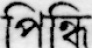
পিন্ধি
